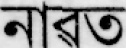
নাৱত
